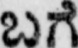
ಬಗೆ
